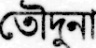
তৌদুনা
